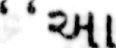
"આ
